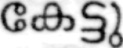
കേട്ടു
